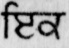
ਇਕ
